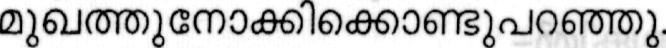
മുഖത്തുനോക്കിക്കൊണ്ടുപറഞ്ഞു.
